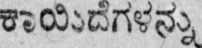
ಕಾಯಿದೆಗಳನ್ನು
